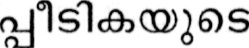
പ്പീടികയുടെ
